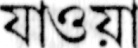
যাওয়া
